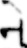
ને
